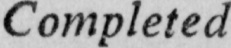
Completed
